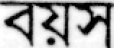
বয়স
